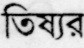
তিষ্যর
